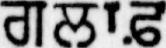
ਗਲਾਫ਼
